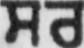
ਸਰ
